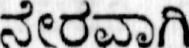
ನೇರವಾಗಿ
